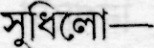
সুধিলো-
